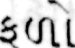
ફળો
